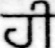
ਹੀ
